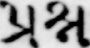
પ્રશ્ર
